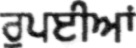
ਰੁਪਈਆਂ
